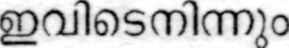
ഇവിടെനിന്നും
